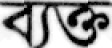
ব্যক্ত
